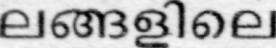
ലങ്ങളിലെ
